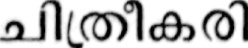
ചിത്രീകരി
